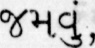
જમવું,
